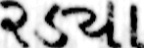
રડ્યા
